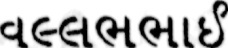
વલ્લભભાઈ
